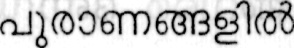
പുരാണങ്ങളില്‍
